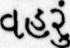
વહરું
